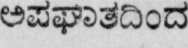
ಅಪಘಾತದಿಂದ
